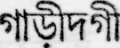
গাড়ীদগী
